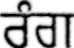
ਰੰਗ
